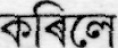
কৰিলে
